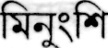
মিনুংশি
